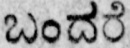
ಬಂದರೆ
